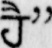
ਹੈ''
